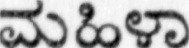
ಮಹಿಳಾ
